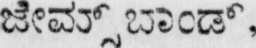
ಜೇಮ್ಸ್ಬಾಂಡ್,
